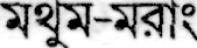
মথুম-মরাং
